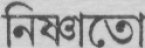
নিষ্ণাতো
